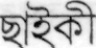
ছাইকী
